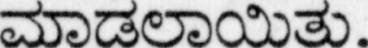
ಮಾಡಲಾಯಿತು.
